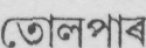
তোলপাৰ
